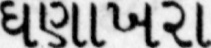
ઘણાખરા
